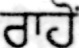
ਰਾਹੋਂ
